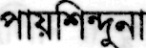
পায়শিন্দুনা
